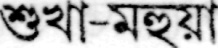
শুখা-মহুয়া
